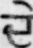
ਦੇ
